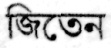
জিতেন
